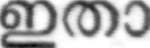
ഇതാ
